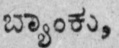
ಬ್ಯಾಂಕು,
